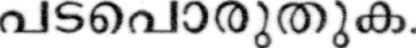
പടപൊരുതുക.
